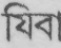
যিবা
